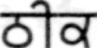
ਠੀਕ
